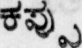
ಕಪ್ಪು
